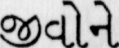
જીવોને
